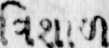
વિશાળ
